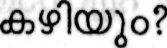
കഴിയും?
